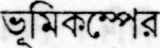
ভূমিকম্পের
